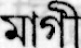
মাগী
